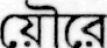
য়ৌরে
